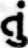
તું
